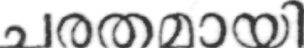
ചരതമായി
